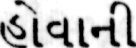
હોવાની
